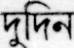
দুদিন
